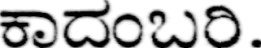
ಕಾದಂಬರಿ.
